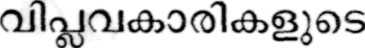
വിപ്ലവകാരികളുടെ
